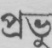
প্ৰভু
